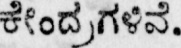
ಕೇಂದ್ರಗಳಿವೆ.
